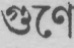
গুণে
